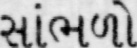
સાંભળો
